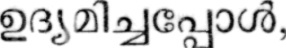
ഉദ്യമിച്ചപ്പോള്‍,
